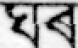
ঘৰ
